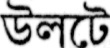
উলটে
